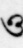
ও
